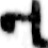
ન
